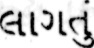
લાગતું
